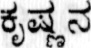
ಕೃಷ್ಣನ
